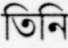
তিনি
